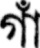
গাঁ
